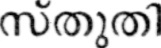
സ്തുതി
